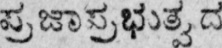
ಪ್ರಜಾಪ್ರಭುತ್ವದ
